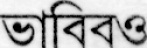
ভাবিবও
